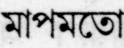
মাপমতো
